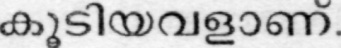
കൂടിയവളാണ്.
